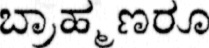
ಬ್ರಾಹ್ಮಣರೂ
